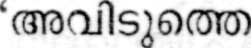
‘അവിടുത്തെ
